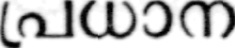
പ്രധാന
